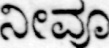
ನೀವೂ
